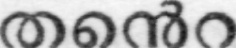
തന്റെ
